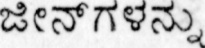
ಜೀನ್‌ಗಳನ್ನು
